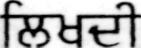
ਲਿਖਦੀ
